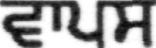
ਵਾਪਸ
